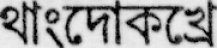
থাংদোকখ্রে
